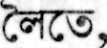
লৈতে,
